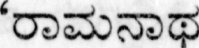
‘ರಾಮನಾಥ
